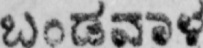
ಬಂಡವಾಳ
